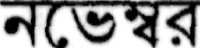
নভেম্বর
